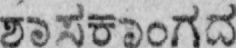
ಶಾಸಕಾಂಗದ
